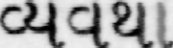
વ્યવથા
